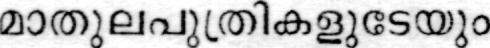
മാതുലപുത്രികളുടേയും
